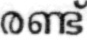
രണ്ട്
